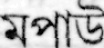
মপাউ
